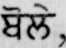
ਬੋਲੇ,
